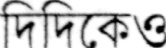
দিদিকেও
